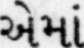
એમાં
